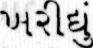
ખરીદ્યું
